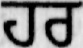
ਹਰ
